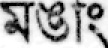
মঙাং
